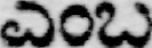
ಎಂಬ
